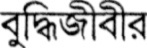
বুদ্ধিজীবীর
